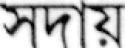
সদায়
